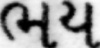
ભય
